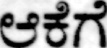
ಆಕೆಗೆ
